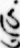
હું
